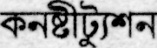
কনষ্টীট্যুশন
